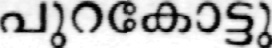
പുറകോട്ടു
